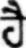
ਹੈ
